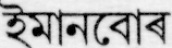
ইমানবোৰ
